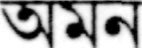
অমন
